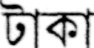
টাকা
